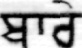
ਬਾਰੇ
